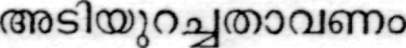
അടിയുറച്ചതാവണം
